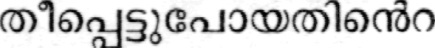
തീപ്പെട്ടുപോയതിന്റെ
